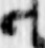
ન
